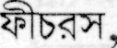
ফীচরস,
